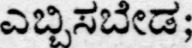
ಎಬ್ಬಿಸಬೇಡ;
